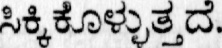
ಸಿಕ್ಕಿಕೊಳ್ಳುತ್ತದೆ.
